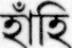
হাঁহি
